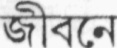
জীবনে
